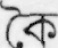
কৈ
